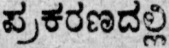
ಪ್ರಕರಣದಲ್ಲಿ
